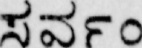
ಸರ್ವಂ
